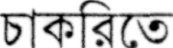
চাকরিতে
